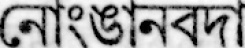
নোংঙানবদা
